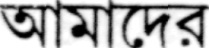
আমাদের
